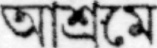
আশ্রমে
